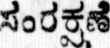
ಸಂರಕ್ಷಣೆ
